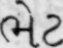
ભેટ
